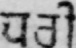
ਧਰੀ
